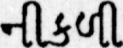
નીકળી
